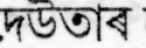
দেউতাৰ
